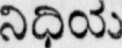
ನಿಧಿಯ
